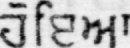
ਹੋਇਆ
